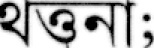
থত্তুনা;
